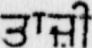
ਤਾਜ਼ੀ
